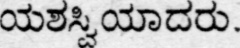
ಯಶಸ್ವಿಯಾದರು.
